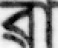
ৱা
